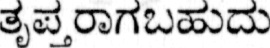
ತೃಪ್ತರಾಗಬಹುದು
